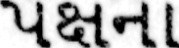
પક્ષના
